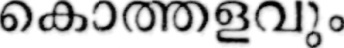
കൊത്തളവും
